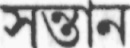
সন্তান
